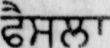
ਫੈਸਲਾ
